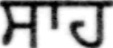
ਸਾਹ
